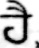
ਹੈ,
